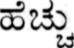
ಹೆಚ್ಚು
